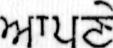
ਆਪਣੇ
